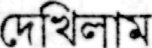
দেখিলাম
